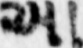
આ
